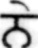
ਨੇ
